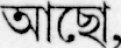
আছো,
